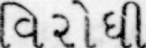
વિરોધી
